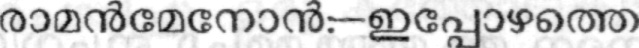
രാമന്‍മേനോന്‍:-ഇപ്പോഴത്തെ
